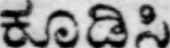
ಕೂಡಿಸಿ
